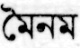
মৈনম
